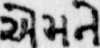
એમને
